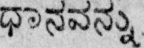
ಧಾನವನ್ನು
